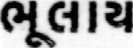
ભૂલાય
